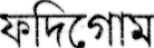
ফদিগোম
